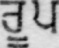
ਰੂਪ
